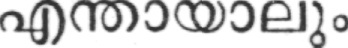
എന്തായാലും
